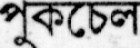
পুকচেল
